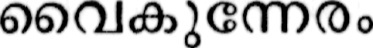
വൈകുന്നേരം
